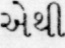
એથી
